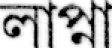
লাপ্না
